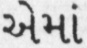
એમાં
